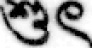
শুৎ
